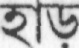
হাড়
